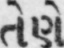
તેણે
